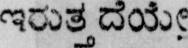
ಇರುತ್ತದೆಯೇ
